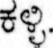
ಕಳ್ಳಿ.
